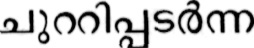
ചുററിപ്പടര്‍ന്ന
